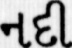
નદી
